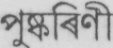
পুষ্কৰিণী
